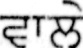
ਵਾਲੇ
